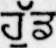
ਹੁੱਡ
